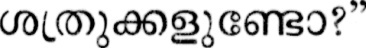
ശത്രുക്കളുണ്ടോ?”
